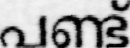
പണ്ട്
